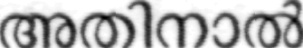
അതിനാല്‍
